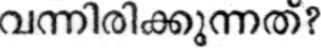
വന്നിരിക്കുന്നത്?
